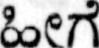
ಹೀಗೆ
